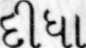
દીધા
